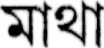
মাথা
